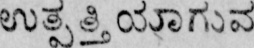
ಉತ್ಪತ್ತಿಯಾಗುವ
